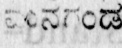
ಮನಗಂಡ
